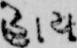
હોય
